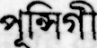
পূন্সিগী
